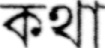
কথা
